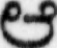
ಆ
